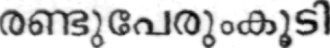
രണ്ടുപേരുംകൂടി
